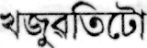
খজুৱতিটো
